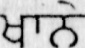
ਖਾਨੇ
